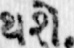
થશે.
